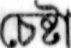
চেষ্টা
